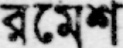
রমেশ
